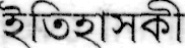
ইতিহাসকী
